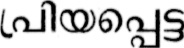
പ്രിയപ്പെട്ട
